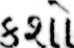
કશો
